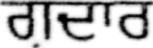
ਗ਼ਦਾਰ
